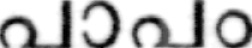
പാപം
